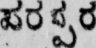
ಪರಸ್ಪರ
